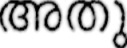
അതു
